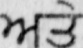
ਅਤੇ
